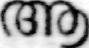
ആ
